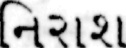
નિરાશ
